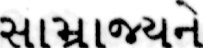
સામ્રાજ્યને
